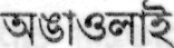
অঙাওলাই
